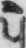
ਪੈ
